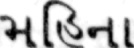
મહિના
